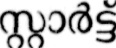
സ്റ്റാര്‍ട്ട്
